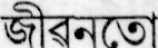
জীৱনতো
